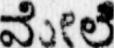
ಮೇಲೆ
